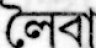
লৈবা
